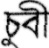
চুবী
